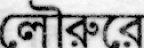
লৌরুরে
